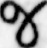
જ
